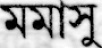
মমাসু
